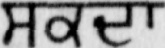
ਸਕਦਾ
